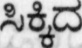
ಸಿಕ್ಕಿದ
